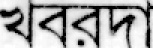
খবরদা
